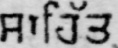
ਸਾਹਿੱਤ
